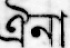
ঐনা
